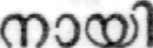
നായി
